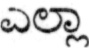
ಎಲ್ಲಾ
